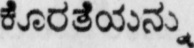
ಕೊರತೆಯನ್ನು
